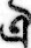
ঐ
